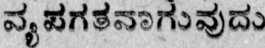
ವ್ಯಪಗತವಾಗುವುದು
